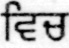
ਵਿਚ
